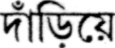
দাঁড়িয়ে
